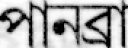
পানব্রা
